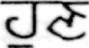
ਹੁਣ
